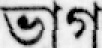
ভাগ
